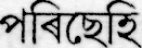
পৰিছেহি
